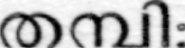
തമ്പി:
